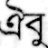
ঐবু
